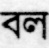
বল
